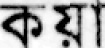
কয়া
